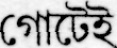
গোটেই
